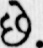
છે.
